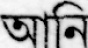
আনি
